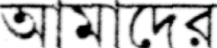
আমাদের
